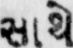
સાથે
